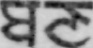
ਬਣ
